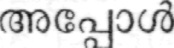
അപ്പോള്‍
